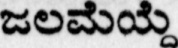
ಜಲಮೆಯ್ದೆ
